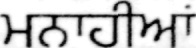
ਮਨਾਹੀਆਂ
